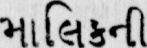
માલિકની
